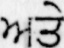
ਅਤੇ
